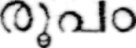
രൂപം
